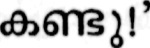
കണ്ടു!’
